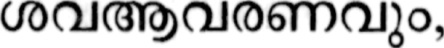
ശവആവരണവും,
